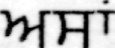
ਅਸਾਂ
